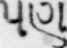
પણ
